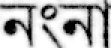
নংনা
